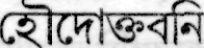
হৌদোক্তবনি
